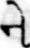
ને
